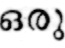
ഒരു
